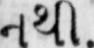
નથી.
